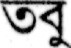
তবু
